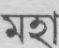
মহা
